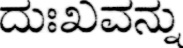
ದುಃಖವನ್ನು
